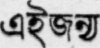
এইজন্য
